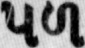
પળ
